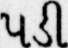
પડી
